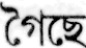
গৈছে
